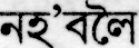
নহ'বলৈ
